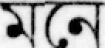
মনে
